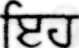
ਇਹ
